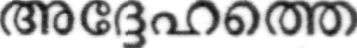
അദ്ദേഹത്തെ
